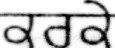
ਕਰਕੇ
